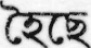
হৈছে
